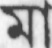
মা
